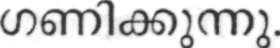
ഗണിക്കുന്നു.
